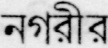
নগরীর
